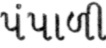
પંપાળી
